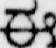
ಈ
